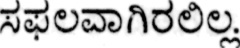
ಸಫಲವಾಗಿರಲಿಲ್ಲ.
